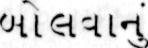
બોલવાનું
